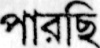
পারছি
